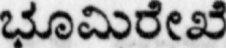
ಭೂಮಿರೇಖೆ
